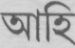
আহি
